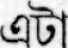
এটা
